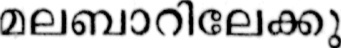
മലബാറിലേക്കു
